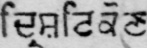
ਦ੍ਰਿਸ਼ਟਿਕੋਣ
